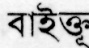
বাইক্তূ
